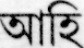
আহি
